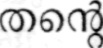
തന്റെ
